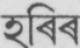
হৰিৰ
